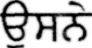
ਉਸਨੇ
